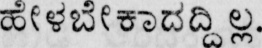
ಹೇಳಬೇಕಾದದ್ದಿಲ್ಲ.
